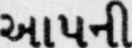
આપની
